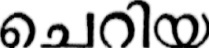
ചെറിയ
